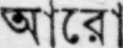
আরো
